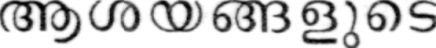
ആശയങ്ങളുടെ
